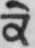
ਕੇ
